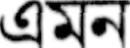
এমন
